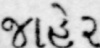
જાહેર
